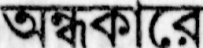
অন্ধকারে
